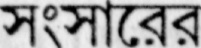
সংসারের
